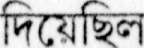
দিয়েছিল
